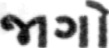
જાગો
